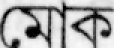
মোক
